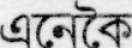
এনেকৈ
